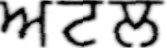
ਅਟਲ
